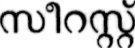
സീറസ്റ്റ്
